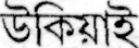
উকিয়াই
